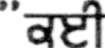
''ਕਈ
